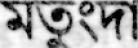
মতুংদা
